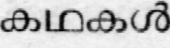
കഥകള്‍
